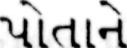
પોતાને
